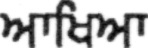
ਆਖਿਆ
